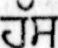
ਹੱਸ
